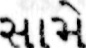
સામે
